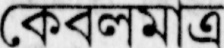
কেবলমাত্র
